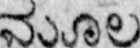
ಮೂಲ
